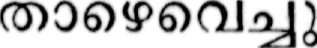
താഴെവെച്ചു
